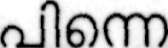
പിന്നെ
